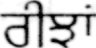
ਰੀਝਾਂ
